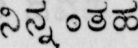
ನಿನ್ನಂತಹ
